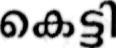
കെട്ടി
